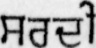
ਸਰਦੀ
